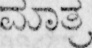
ಮಾತ್ರ
